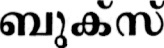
ബുക്സ്
